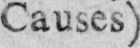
Causes)
